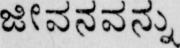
ಜೀವನವನ್ನು
